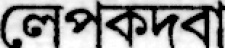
লেপকদবা
